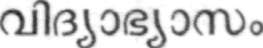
വിദ്യാഭ്യാസം
